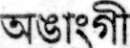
অঙাংগী
